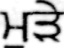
ਮੁੜੇ
